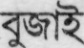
বুজাই
